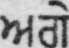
ਅਗੇ
